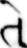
તે
